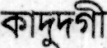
কাদুদগী
